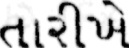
તારીખે
